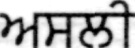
ਅਸਲੀ
